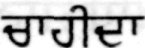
ਚਾਹੀਦਾ
